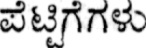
ಪೆಟ್ಟಿಗೆಗಳು
